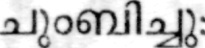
ചുംബിച്ചു:
